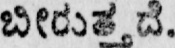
ಬೀರುತ್ತದೆ.
